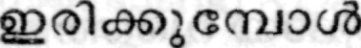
ഇരിക്കുമ്പോള്‍
